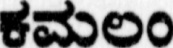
ಕಮಲಂ
